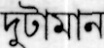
দুটামান
